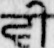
ਵੀ
